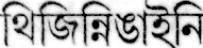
থিজিন্নিঙাইনি
